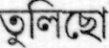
তুলিছো
